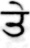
ਤੇ
